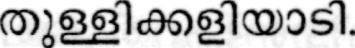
തുള്ളിക്കളിയാടി.
